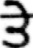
ਤੇ
